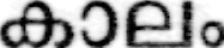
കാലം
